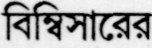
বিম্বিসারের
